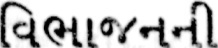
વિભાજનની
